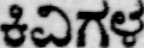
ಕಿವಿಗಳ
